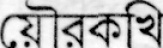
য়ৌরকখি
